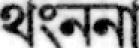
থংননা
